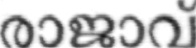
രാജാവ്
